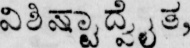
ವಿಶಿಷ್ಟಾದ್ವೈತ,
